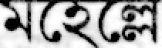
মহেল্লে
